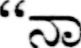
"ನಾ
